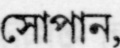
সোপান,
